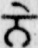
ਨੇ
